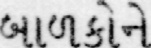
બાળકોને
